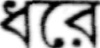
ধরে
